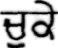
ਚੁਕੇ
